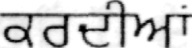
ਕਰਦੀਆਂ
